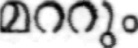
മററും
